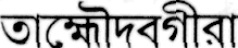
তাহ্মৌদবগীরা
